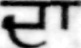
ਦਾ
